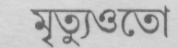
মৃত্যুওতো
